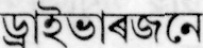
ড্ৰাইভাৰজনে
